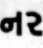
નર
